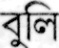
বুলি
